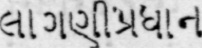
પ્રધાન
